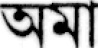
অমা
